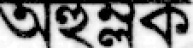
অহুম্লক
